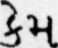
કેમ
